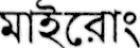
মাইরোং
